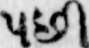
પછી
